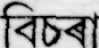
বিচৰা
